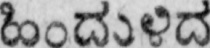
ಹಿಂದುಳಿದ
